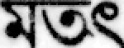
মতৎ
